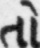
તો
